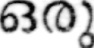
ഒരു
